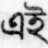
এই
